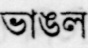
ভাঙল
